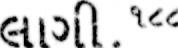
લાગી.૧૮૮
